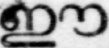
ഈ
